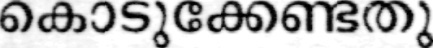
കൊടുക്കേണ്ടതു
